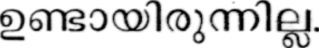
ഉണ്ടായിരുന്നില്ല.
